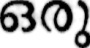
ഒരു
